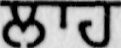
ਲਾਹ
